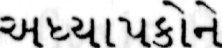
અધ્યાપકોને
